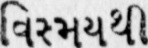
વિસ્મયથી
